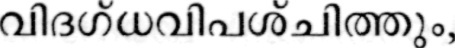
വിദഗ്ധവിപശ്ചിത്തും,
